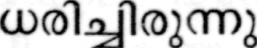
ധരിച്ചിരുന്നു
